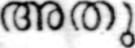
അതു
